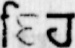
ਇਹ
